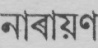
নাৰায়ণ
